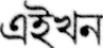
এইখন
